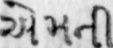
એમની
